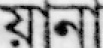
য়ানা
